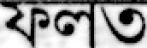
ফলত
